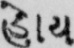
હોય
